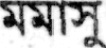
মমাসু
